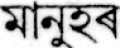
মানুহৰ
